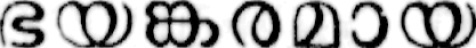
ഭയങ്കരമായ
